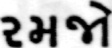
રમજો
